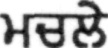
ਮਚਲੇ
